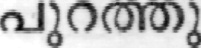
പുറത്തു
